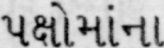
પક્ષોમાંના
